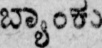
ಬ್ಯಾಂಕು
